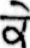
ਕੇ
